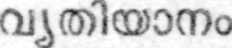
വ്യതിയാനം
